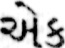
એક
